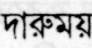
দারুময়
